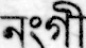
নংগী
